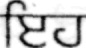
ਇਹ
